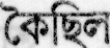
কৈছিল
